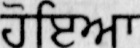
ਹੋਇਆ
